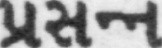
પ્રસન્ન
